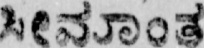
ಸೀಮಾಂತ
